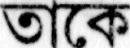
তাকে
